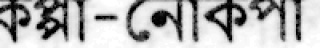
কপ্পা-নোকপা
